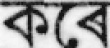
কৰে
